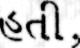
હતી,
